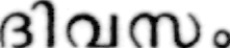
ദിവസം
